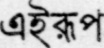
এইরূপ
